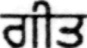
ਗੀਤ
